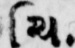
ચિ.
